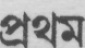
প্ৰথম
